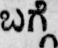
ಬಗ್ಗೆ
